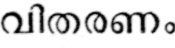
വിതരണം
